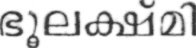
ഭൂലക്ഷ്മി
